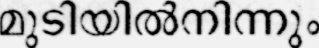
മുടിയില്‍നിന്നും
